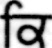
ਕਿ
